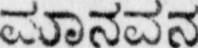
ಮಾನವನ
